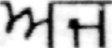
ਅਜ
